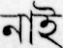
নাই
